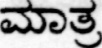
ಮಾತ್ರ
